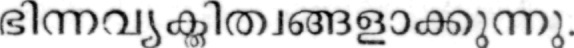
ഭിന്നവ്യക്തിത്വങ്ങളാക്കുന്നു.
